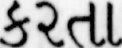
કરતા
